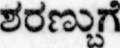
ಶರಣ್ಬುಗೆ
